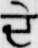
ਦੇ
